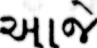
આજે
